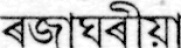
ৰজাঘৰীয়া
